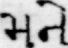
મને
